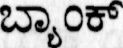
ಬ್ಯಾಂಕ್
